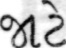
જાટે
